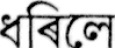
ধৰিলে
